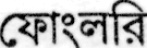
ফোংলরি
